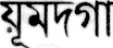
য়ূমদগা
